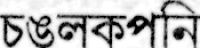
চঙলকপনি
